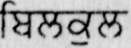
ਬਿਲਕੁਲ
